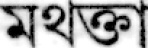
মথক্তা
